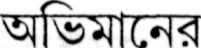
অভিমানের
